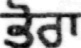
ਭੋਰਾ
